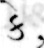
કે,
